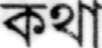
কথা
